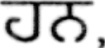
ਹਨ,
